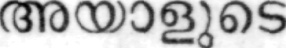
അയാളുടെ
